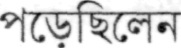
পড়েছিলেন
